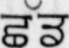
ਛੱਡ
